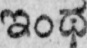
ಇಂಥ
